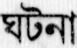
ঘটনা
